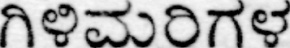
ಗಿಳಿಮರಿಗಳ
